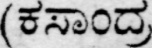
(ಕಸಾಂದ್ರ
